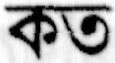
কত
